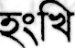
হংখি
